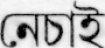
নেচাই
